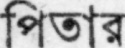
পিতার
